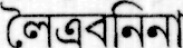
লৈত্রবনিনা
